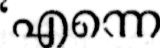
‘എന്നെ
